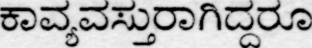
ಕಾವ್ಯವಸ್ತುರಾಗಿದ್ದರೂ
